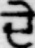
ਦੇ
